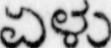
ಏಳು
